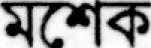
মশেক
